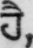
ਹੈ,
